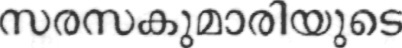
സരസകുമാരിയുടെ
